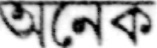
অনেক
